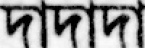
দাদাদা
